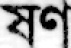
ষণ
